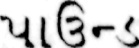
પાઉન્ડ
